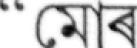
"মোৰ
